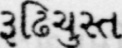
રૂઢિચુસ્ત
